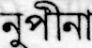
নুপীনা
